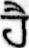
ਹੈ
